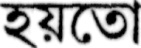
হয়তো
